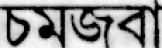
চমজবা
